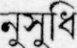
নুসুধি
